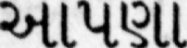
આપણા
